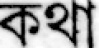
কথা
